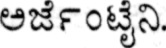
ಅರ್ಜೆಂಟೈನಿ.
